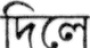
দিলে
